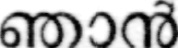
ഞാന്‍
